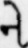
ને
